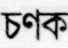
চণক
